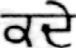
ਕਦੇ
